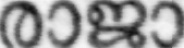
രാജാ
